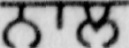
ਨਾਲ
